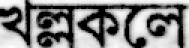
খল্লকলে
